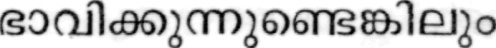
ഭാവിക്കുന്നുണ്ടെങ്കിലും
